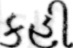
કહી
